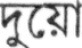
দুয়ো
